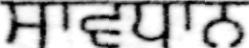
ਸਾਵਧਾਨ
